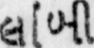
લાંબી
